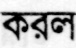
করল
